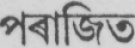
পৰাজিত
